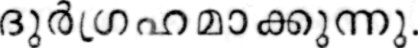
ദുര്‍ഗ്രഹമാക്കുന്നു.
